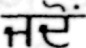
ਜਦੋਂ
